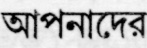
আপনাদের
